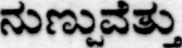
ನುಣ್ಪುವೆತ್ತು
